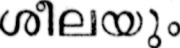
ശീലയും
